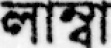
লাম্বা
